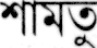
শামতু
